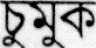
চুমুক
